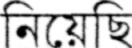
নিয়েছি
